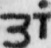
ਤਾਂ
